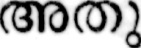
അതു
